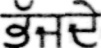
ਭੱਜਦੇ
